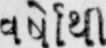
વર્ષોથી
